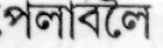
পেলাবলৈ
